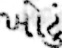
ખોટું
